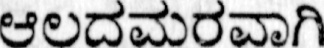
ಆಲದಮರವಾಗಿ
